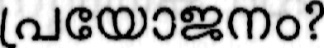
പ്രയോജനം?
